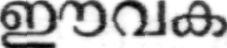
ഈവക
